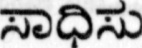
ಸಾಧಿಸು
